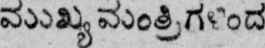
ಮುಖ್ಯಮಂತ್ರಿಗಳಿಂದ
